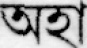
অহা
